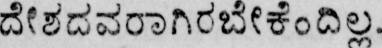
ದೇಶದವರಾಗಿರಬೇಕೆಂದಿಲ್ಲ.
